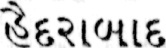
હૈદરાબાદ
